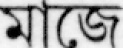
মাজে
